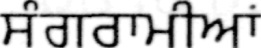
ਸੰਗਰਾਮੀਆਂ
